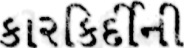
કારકિર્દીની
